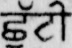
ਛੁੱਟੀ
